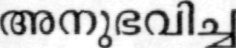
അനുഭവിച്ച
